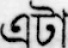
এটা
